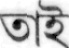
তাই
